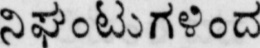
ನಿಘಂಟುಗಳಿಂದ
